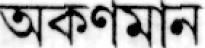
অকণমান
